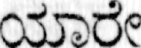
ಯಾರೇ
